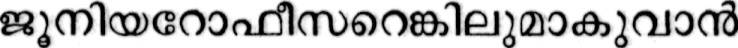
ജൂനിയറോഫീസറെങ്കിലുമാകുവാന്‍
